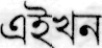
এইখন
